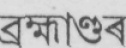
ব্ৰহ্মাণ্ডৰ
